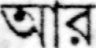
আর
